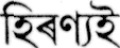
হিৰণ্যই
